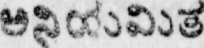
ಅನಿಯಮಿತ
